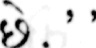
છે."
